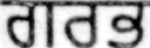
ਗਰਭ
